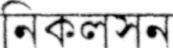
নিকলসন
